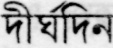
দীর্ঘদিন
